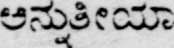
ಅನ್ನುತೀಯಾ
